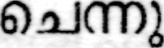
ചെന്നു
